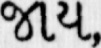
જાય,
